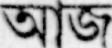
আজ
